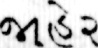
જાહેર
